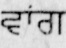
ਵਾਂਗ
